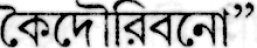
কৈদৌরিবনো”
